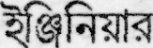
ইঞ্জিনিয়ার
